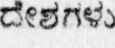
ದೇಶಗಳು
